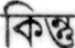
কিন্তু
